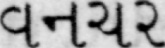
વનચર
